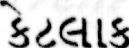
કેટલાક
